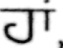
ਹਾਂ,
